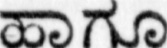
ಹಾಗೂ
